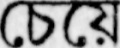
চেয়ে
